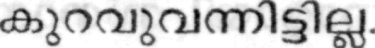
കുറവുവന്നിട്ടില്ല.
